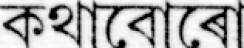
কথাবোৰো
